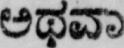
ಅಥವಾ
